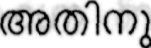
അതിനു
